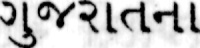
ગુજરાતના
